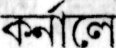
কর্নালে
